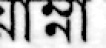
য়াম্না
